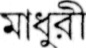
মাধুরী
